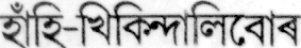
হাঁহি-খিকিন্দালিবোৰ
